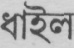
ধাইল
